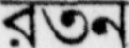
রতন
